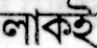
লাকই
